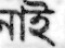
নাই
